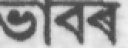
ভাবৰ
